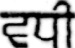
ਵਧੀ
